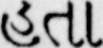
હતા
